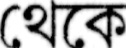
থেকে
